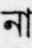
না
